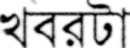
খবরটা
